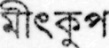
মীৎকুপ
